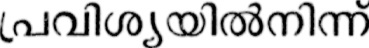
പ്രവിശ്യയില്‍നിന്ന്
